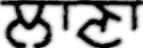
ਲਾਣਾ
